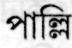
পাল্লি
